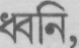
ধ্বনি,
